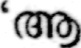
‘ആ
